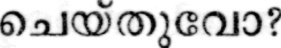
ചെയ്തുവോ?
